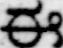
ಈ
